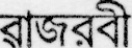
ৱাজরবী
